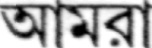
আমরা
